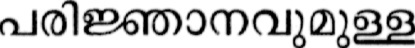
പരിജ്ഞാനവുമുള്ള
